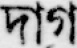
দাগ
